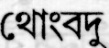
থোংবদু
